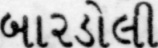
બારડોલી
